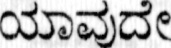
ಯಾವುದೇ
